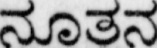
ನೂತನ
